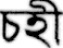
চহী
